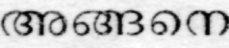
അങ്ങനെ
